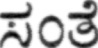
ಸಂತೆ
